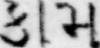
કામ
